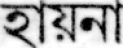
হায়না
